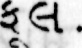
ફૂલ.
